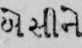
બેસીને
